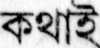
কথাই
